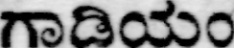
ಗಾಡಿಯಂ
